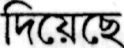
দিয়েছে
